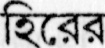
হিরের
